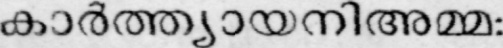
കാര്‍ത്ത്യായനിഅമ്മ:
